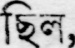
ছিল,
